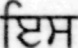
ਇਸ
